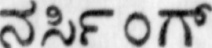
ನರ್ಸಿಂಗ್
